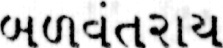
બળવંતરાય
